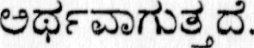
ಅರ್ಥವಾಗುತ್ತದೆ.
